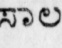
ಸಾಲ
